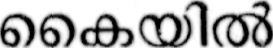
കൈയില്‍
